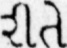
રીતે
